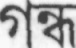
গন্ধ
